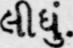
લીધું.
